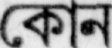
কোন
